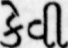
કેવી
